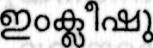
ഇംക്ലീഷു
